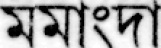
মমাংদা
